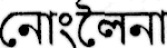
নোংলৈনা
